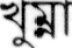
খুম্না
